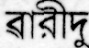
ৱারীদু
